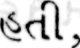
હતી,
